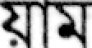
য়াম
